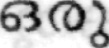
ഒരു
